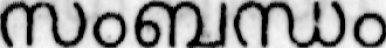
സംബന്ധം
